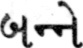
બન્ને
